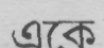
একে
